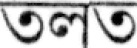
তলত
